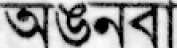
অঙনবা
